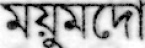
ময়ুমদো
